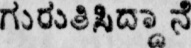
ಗುರುತಿಸಿದ್ದಾನೆ
